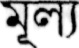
মূল্য
